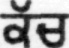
ਕੱਚ
